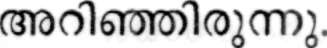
അറിഞ്ഞിരുന്നു.
